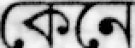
কেনে
